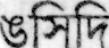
ঙসিদি
